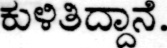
ಕುಳಿತಿದ್ದಾನೆ.
